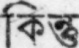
কিন্তু
